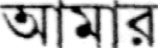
আমার
